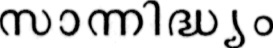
സാന്നിദ്ധ്യം
